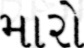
મારો
